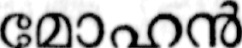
മോഹന്‍
